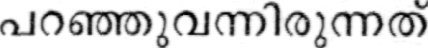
പറഞ്ഞുവന്നിരുന്നത്
